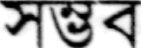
সম্ভব
